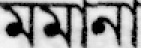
মমানা
